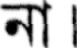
না।
